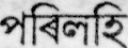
পৰিলহি
